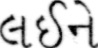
લઈને
